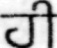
ਹੀ
